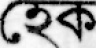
হেক
